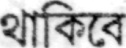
থাকিবে
